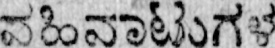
ವಹಿವಾಟುಗಳ
